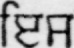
ਇਸ
